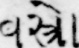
વસ્ત્રો
